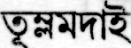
তুম্লমদাইদা
